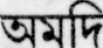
অমদি
